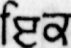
ਇਕ
